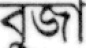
বুজা
